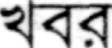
খবর
